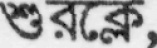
শুরক্লে,
